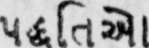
પદ્ધતિઓ
